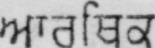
ਆਰਥਿਕ
